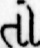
તો
